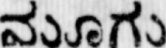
ಮೂಗು
